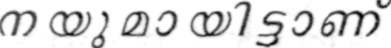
നയുമായിട്ടാണ്
